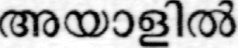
അയാളില്‍
